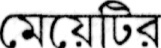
মেয়েটির
